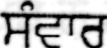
ਸੰਵਾਰ
